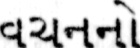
વચનનો
